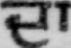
ਦਾ
